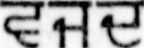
ਵਜਦ
